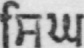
ਸਿਘ
